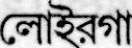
লোইরগা
